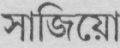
সাজিয়ো
